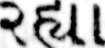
રહ્યા
